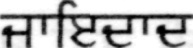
ਜਾਇਦਾਦ
